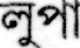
লুপা
